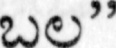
ಬಲ"
